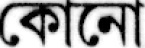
কোনো
